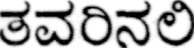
ತವರಿನಲಿ
